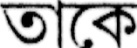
তাকে
